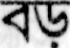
বড়
